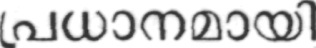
പ്രധാനമായി
